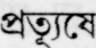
প্রত্যূষে
